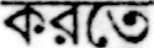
করতে
